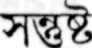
সন্তুষ্ট
